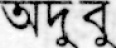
অদুবু
